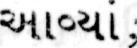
આવ્યાં,
